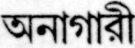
অনাগারী
